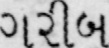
ગરીબ
